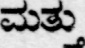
ಮತ್ತು
